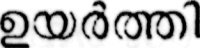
ഉയര്‍ത്തി
